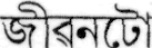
জীৱনটো
